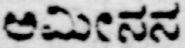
ಅಮೀನನ
